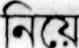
নিয়ে
